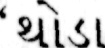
"થોડા
